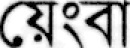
য়েংবা
